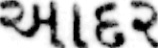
આદર
